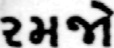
રમજો
